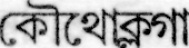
কৌথোক্লগা
